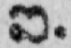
ಐ.
